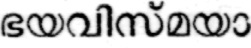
ഭയവിസ്മയാ
